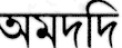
অমদদি
